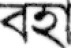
বহা
